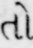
તો
